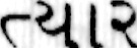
ત્યાર
